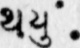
થયું.
